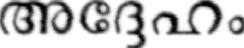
അദ്ദേഹം
